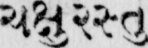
ચક્ષુરસ્તુ
